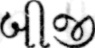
બીજી
